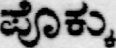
ಪೊಕ್ಕು
